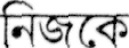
নিজকে
